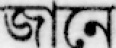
জানে
